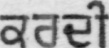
ਕਰਦੀ
